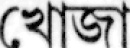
খোজা
